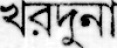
খরদুনা
